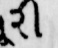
પૂરી
